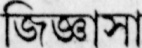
জিজ্ঞাসা
